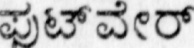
ಫುಟ್ ವೇರ್
